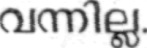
വന്നില്ല.
